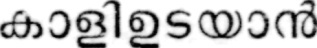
കാളിഉടയാന്‍
